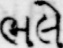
ભલે
